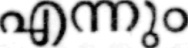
എന്നും
